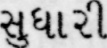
સુધારી
